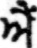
ਐਂ
